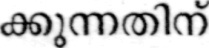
ക്കുന്നതിന്
